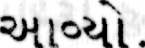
આવ્યો.
